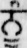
ਨੂੰ
